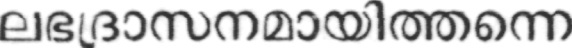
ലഭദ്രാസനമായിത്തന്നെ
